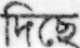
দিছে
